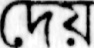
দেয়
